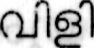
വിളി
